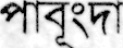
পাবূদা
